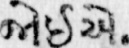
જોઈએ.
